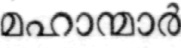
മഹാന്മാര്‍
